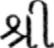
શ્રી
